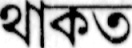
থাকত
